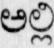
ಅಲ್ಲಿ
